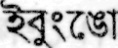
ইবুংঙো
